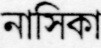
নাসিকা
